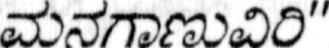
ಮನಗಾಣುವಿರಿ”
